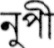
নুপী
